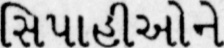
સિપાહીઓને
